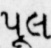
પૂલ
